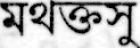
মথক্তসু
